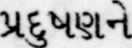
પ્રદુષણને
